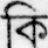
কি
